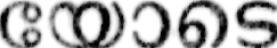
യോടെ
